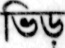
ভিড়
